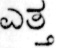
ಎತ್ತ
